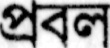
প্রবল
